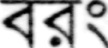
বরং
